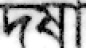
দষা
